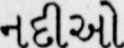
નદીઓ
